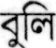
বুলি
